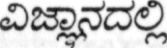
ವಿಜ್ಞಾನದಲ್ಲಿ
